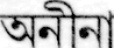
অনীনা
